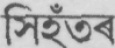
সিহঁতৰ
